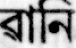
ৱানি
